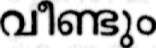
വീണ്ടും
